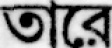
তারে
